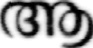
ആ
